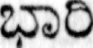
ಭಾರಿ
